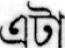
এটা
